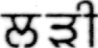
ਲੜੀ
